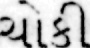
ચોકી
